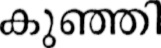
കുഞ്ഞി
